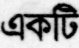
একটি
